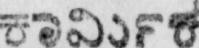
ಕಾರ್ಮಿಕ
